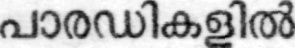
പാരഡികളില്‍
